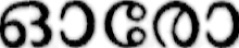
ഓരോ
